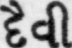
દૈવી
